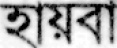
হায়বা
